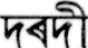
দৰদী
